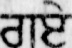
ਗਏ
